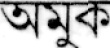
অমুক
